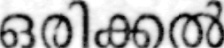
ഒരിക്കല്‍
